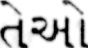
તેઓ
